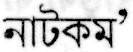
নাটকম’
